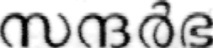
സന്ദര്‍ഭ
